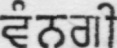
ਵੰਨਗੀ
